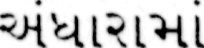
અંધારામાં
